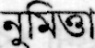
নুমিত্তা
